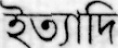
ইত্যাদি
